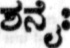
ಶನೈಃ
